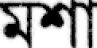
মশা
